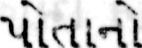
પોતાનો
